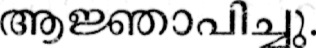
ആജ്ഞാപിച്ചു.
